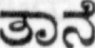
ತಾನೆ
